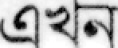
এখন
